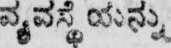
ವ್ಯವಸ್ಥೆಯನ್ನು
